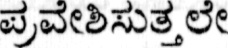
ಪ್ರವೇಶಿಸುತ್ತಲೇ
